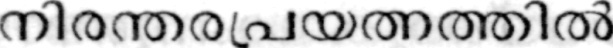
നിരന്തരപ്രയത്നത്തില്‍
